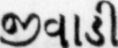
જીવાડી
